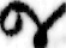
જ
